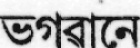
ভগৱানে
